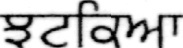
ਝਟਕਿਆ
